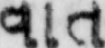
વાત
